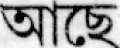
আছে
